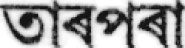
তাৰপৰা
